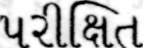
પરીક્ષિત
